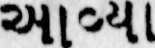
આવ્યા
